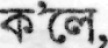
ক'লে,
